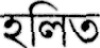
হলিত
